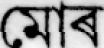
মোৰ
